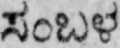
ಸಂಬಳ
